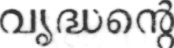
വൃദ്ധന്റെ
